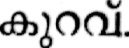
കുറവ്.
